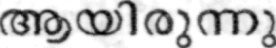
ആയിരുന്നു
